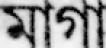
মাগা
